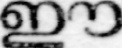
ഈ
